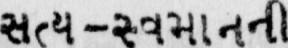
સત્ય-સ્વમાનની
